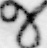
જ
